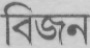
বিজন
